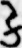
કે
